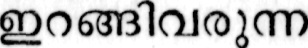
ഇറങ്ങിവരുന്ന
